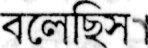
বলেছিস।
